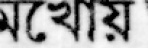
মখোয়
